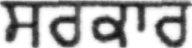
ਸਰਕਾਰ
